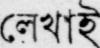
লেখাই
